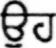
ਉਹ
